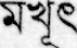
মখূৎ
